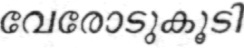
വേരോടുകൂടി
